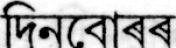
দিনবোৰৰ
